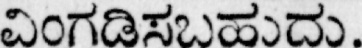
ವಿಂಗಡಿಸಬಹುದು.
